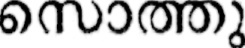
സൊത്തു
